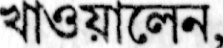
খাওয়ালেন,
